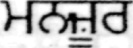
ਮਨਜ਼ੂਰ
